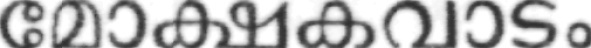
മോക്ഷകവാടം
